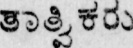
ತಾತ್ವಿಕರು
